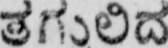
ತಗುಲಿದ
